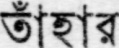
তাঁহার
